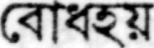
বোধহয়
